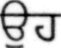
ਉਹ
